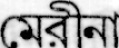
মেরীনা
